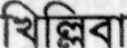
খিল্লিবা
